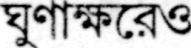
ঘুণাক্ষরেও
